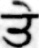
ਤੇ
